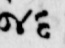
જિદ
